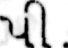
પી.
